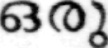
ഒരു
